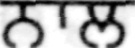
ਨਾਲ
